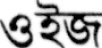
ওইজ
